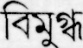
বিমুগ্ধ
